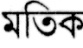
মতিক
